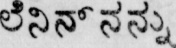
ಲೆನಿನ್ ನನ್ನು
